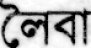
লৈবা
